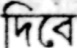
দিবে
